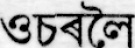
ওচৰলৈ
